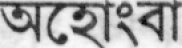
অহোংবা
